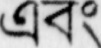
এবং
